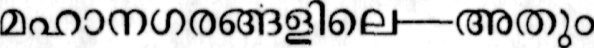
മഹാനഗരങ്ങളിലെ-അതും
